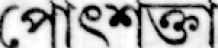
পোৎশক্তা
